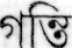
গন্তি
